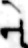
ને
